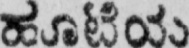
ಹೂಟೆಯ
